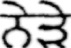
ਨੇੜੇ
